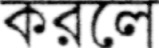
করলে
